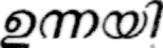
ഉന്നയി
